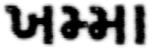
ખમ્મા
